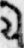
યે
